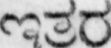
ಇತರ
